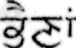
ਭੈਣਾਂ
